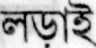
লড়াই
